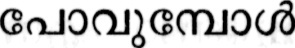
പോവുമ്പോള്‍
